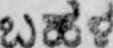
ಬಹಳ
